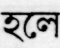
হলে
